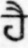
ਹੈ
